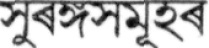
সুৰঙ্গসমূহৰ
